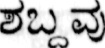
ಶಬ್ದವು
